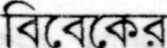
বিবেকের
